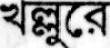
খল্লুরে
